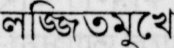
লজ্জিতমুখে
